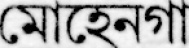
মোহেনগা
